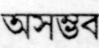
অসম্ভব
